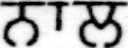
ਨਾਲ
